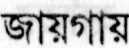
জায়গায়
